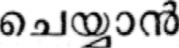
ചെയ്യാന്‍
